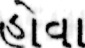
હોવા
